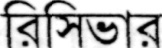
রিসিভার
